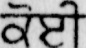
ਕੋਈ
